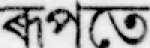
ৰূপতে
